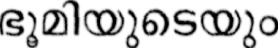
ഭൂമിയുടെയും
